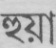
হুয়া
